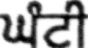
ਘੰਟੀ
